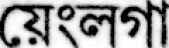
য়েংলগা
